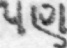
પણ
